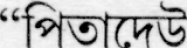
"পিতাদেউ
